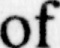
of
